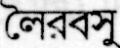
লৈরবসু
